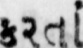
કરતાં
